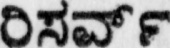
ರಿಸರ್ವ್
